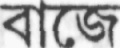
বাজে
